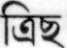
ত্রিছ
